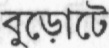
বুড়োটে
